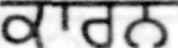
ਕਾਰਨ
